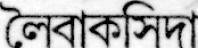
লৈবাকসিদা
